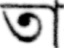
তা
